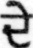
ਦੇ
